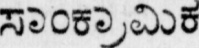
ಸಾಂಕ್ರಾಮಿಕ
